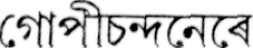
গোপীচন্দনেৰে
